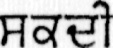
ਸਕਦੀ
